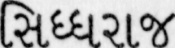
સિધ્ધરાજ
